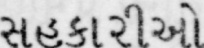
સહકારીઓ
